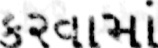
કરવામાં
